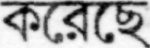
করেছে
